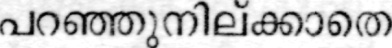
പറഞ്ഞുനില്ക്കാതെ
